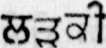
ਲੜਕੀ
